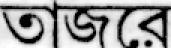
তাজরে
